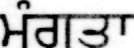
ਮੰਗਤਾ
